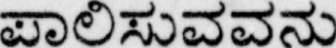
ಪಾಲಿಸುವವನು
